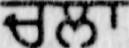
ਚਲਾ
